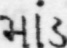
માંડ
